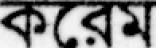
করেম
